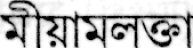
মীয়ামলক্তা
